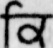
ਕਿ
